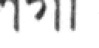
নগা
